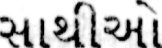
સાથીઓ
